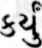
કર્યું
